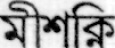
মীশক্নি
